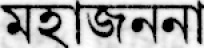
মহাজননা
